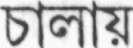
চালায়
